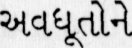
અવધૂતોને
